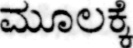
ಮೂಲಕ್ಕೆ
